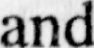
and
